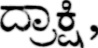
ದ್ರಾಕ್ಷಿ,
